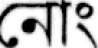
নোং
